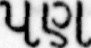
પણ
